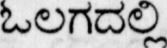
ಓಲಗದಲ್ಲಿ
